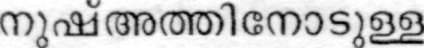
നുഷ്അത്തിനോടുള്ള
